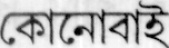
কোনোবাই
